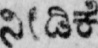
ನೀಡಿಕೆ
